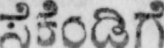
ಸೆಕೆಂಡಿಗೆ
